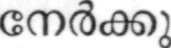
നേര്‍ക്കു
